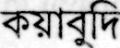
কয়াবুদি
